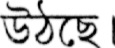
উঠছে।
